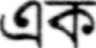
এক
